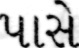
પાસે
